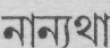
নান্যথা
